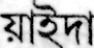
য়াইদা
